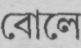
বোলে
